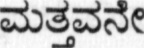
ಮತ್ತವನೇ
